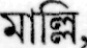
মাল্লি,
